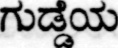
ಗುಡ್ಡೆಯ
